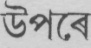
উপৰে
